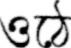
ওঠে
